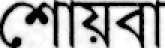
শোয়বা
